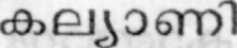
കല്യാണി
